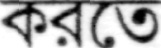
করতে
